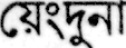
য়েংদুনা
